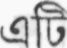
এটি
